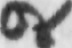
જ
